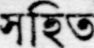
সহিত
